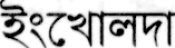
ইংখোলদা
